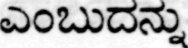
ಎಂಬುದನ್ನು
